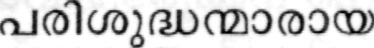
പരിശുദ്ധന്മാരായ
